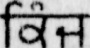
ਕਿੰਜ
